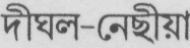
দীঘল-নেছীয়া
